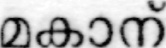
മകാന്
